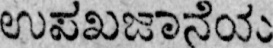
ಉಪಖಜಾನೆಯ
